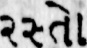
રસ્તો
